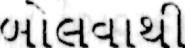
બોલવાથી
